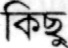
কিছু
